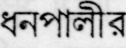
ধনপালীর
